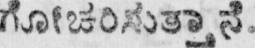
ಗೋಚರಿಸುತ್ತಾನೆ.
